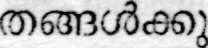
തങ്ങള്‍ക്കു
